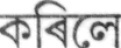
কৰিলে
